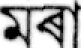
মৰা
